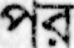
পর
